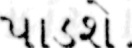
પાડશે.
